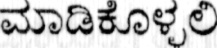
ಮಾಡಿಕೊಳ್ಳಲಿ
